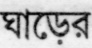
ঘাড়ের
